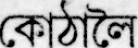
কোঠালৈ
